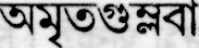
অমৃতগুম্লবা
